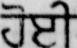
ਹੋਈ
